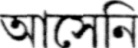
আসেনি
